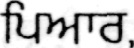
ਪਿਆਰ,
